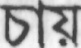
চায়
